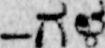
-ಗಳ
